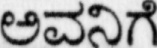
ಅವನಿಗೆ
